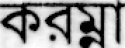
করম্না
